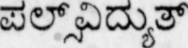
ಪಲ್ಸ್‌ವಿದ್ಯುತ್
